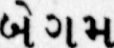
બેગમ
